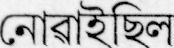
নোৱাইছিল
